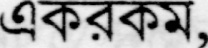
একরকম,
